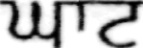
ਘਾਟ
